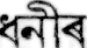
ধনীৰ
